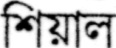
শিয়াল
